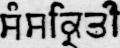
ਸੰਸਕ੍ਰਿਤੀ
